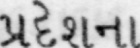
પ્રદેશના
